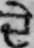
ਦੇ
